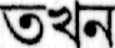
তখন
